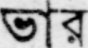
ভার
